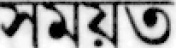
সময়ত
